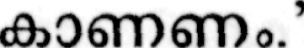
കാണണം.’
